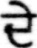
ਦੇ
